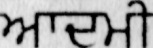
ਆਦਮੀ
